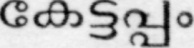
കേട്ടപ്പം
